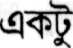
একটু
